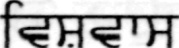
ਵਿਸ਼ਵਾਸ
